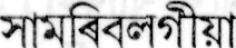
সামৰিবলগীয়া
